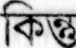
কিন্তু
